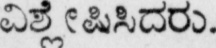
ವಿಶ್ಲೇಷಿಸಿದರು.
